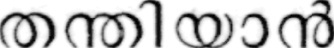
തന്തിയാന്‍
